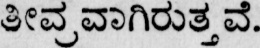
ತೀವ್ರವಾಗಿರುತ್ತವೆ.
